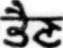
ਭੈਣ
